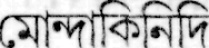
মোন্দাকিনিদি
